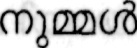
നുമ്മള്‍
